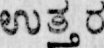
ಉತ್ತರ
